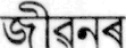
জীৱনৰ
